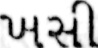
ખસી
